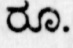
ರೂ.
